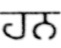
ਹਨ
